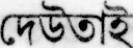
দেউতাই
